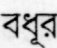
বধূর
